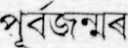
পূর্বজন্মৰ
